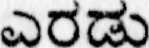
ಎರಡು
